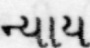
ન્યાય
